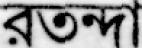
রতন্দা
